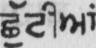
ਛੁੱਟੀਆ
